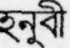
হনুবী
